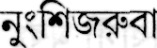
নুংশিজরুবা
